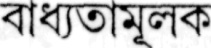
বাধ্যতামূলক
